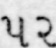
પર
